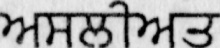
ਅਸਲੀਅਤ
